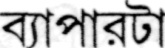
ব্যাপারটা
